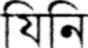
যিনি
